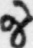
જે
